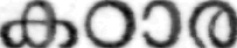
കഠാര
